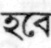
হবে
